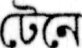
টেনে
